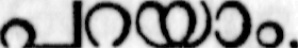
പറയാം.
